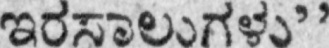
ಇರಸಾಲುಗಳು"
